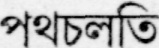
পথচলতি
